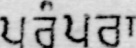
ਪਰੰਪਰਾ
